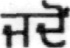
ਜਦੋਂ
